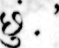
છું.'
